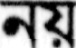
নয়
